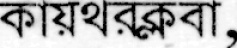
কায়থরক্লবা,
